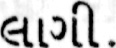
લાગી.
